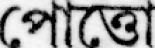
পোত্তো
